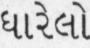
ધારેલો
